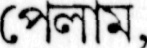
পেলাম,
